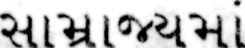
સામ્રાજ્યમાં
